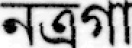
নত্রগা
